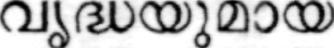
വൃദ്ധയുമായ
